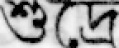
শুদ্রে
